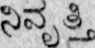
ನಿವೃತ್ತಿ
